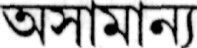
অসামান্য
